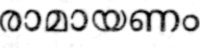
രാമായണം
